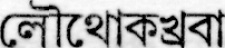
লৌথোকখ্রবা
